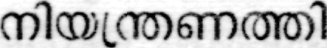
നിയന്ത്രണത്തി
